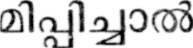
മിപ്പിച്ചാല്‍
